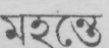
মহন্তে
